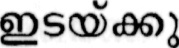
ഇടയ്ക്കു
